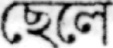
ছেলে
